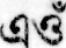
এওঁ
